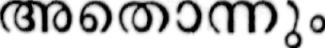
അതൊന്നും
